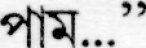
পাম..."
